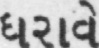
ધરાવે
